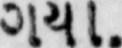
ગયા.
